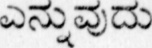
ಎನ್ನುವುದು
